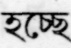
হচ্ছে
